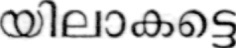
യിലാകട്ടെ
